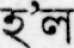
হ'ল
